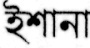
ইশানা
